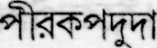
পীরকপদুদা
